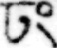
ঢং
